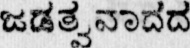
ಜಡತ್ವವಾದದ
